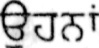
ਉਹਨਾਂ
